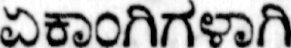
ಏಕಾಂಗಿಗಳಾಗಿ
